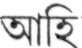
আহি
